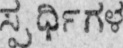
ಸ್ಪರ್ಧಿಗಳ
